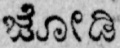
ಜೋಡಿ
